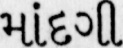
માંદગી
